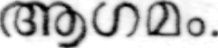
ആഗമം.
